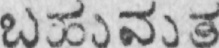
ಬಹುಮತ
